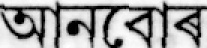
আনবোৰ
